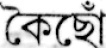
কৈছোঁ
